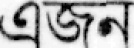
এজন
